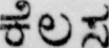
ಕೆಲಸ
